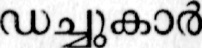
ഡച്ചുകാര്‍
